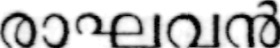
രാഘവന്‍
